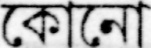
কোনো
